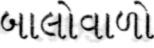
બાલોવાળો
